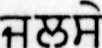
ਜਲਸੇ
